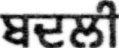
ਬਦਲੀ
